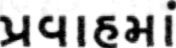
પ્રવાહમાં
